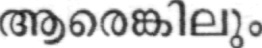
ആരെങ്കിലും
